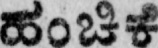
ಹಂಚಿಕೆ
